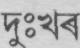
দুঃখৰ
